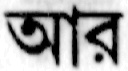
আর
